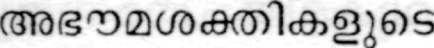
അഭൌമശക്തികളുടെ
